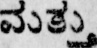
ಮತ್ತು
